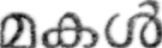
മകള്‍
